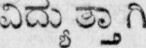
ವಿದ್ಯುತ್ತಾಗಿ
